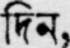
দিন,
